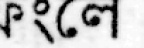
ফংলে
